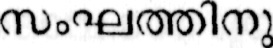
സംഘത്തിനു
